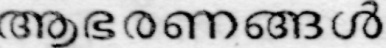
ആഭരണങ്ങള്‍
